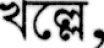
খল্লে,
